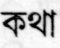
কথা
